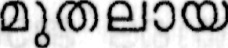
മുതലായ
